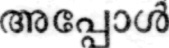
അപ്പോള്‍
